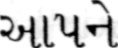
આપને
